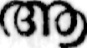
ആ
